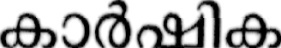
കാര്‍ഷിക
